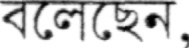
বলেছেন,
